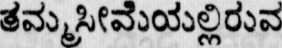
ತಮ್ಮಸೀಮೆಯಲ್ಲಿರುವ
